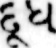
દૂધ
